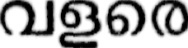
വളരെ
